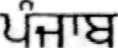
ਪੰਜਾਬ
